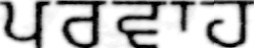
ਪਰਵਾਹ
